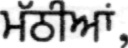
ਮੱਠੀਆਂ,
